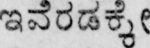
ಇವೆರಡಕ್ಕೇ
